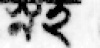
স্নেহ
